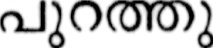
പുറത്തു
